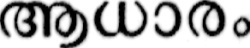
ആധാരം
